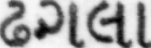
ઢગલાં
